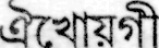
ঐখোয়গী
